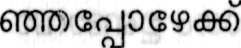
ഞ്ഞപ്പോഴേക്ക്
